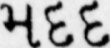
મદદ
